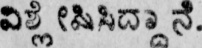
ವಿಶ್ಲೇಷಿಸಿದ್ದಾನೆ.
